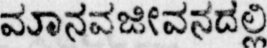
ಮಾನವಜೀವನದಲ್ಲಿ
